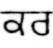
ਕਰ
